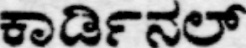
ಕಾರ್ಡಿನಲ್
